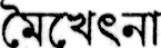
মৈখেৎনা
